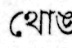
থোঙ
